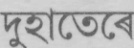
দুহাতেৰে
